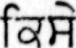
ਕਿਸੇ
